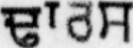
ਢਾਰਸ
